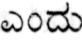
ಎಂದು
